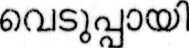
വെടുപ്പായി
